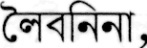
লৈবনিনা,
